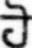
ਹੋ
